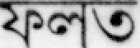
ফলত
